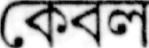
কেবল
